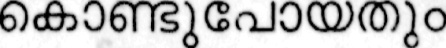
കൊണ്ടുപോയതും
